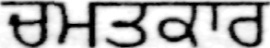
ਚਮਤਕਾਰ
